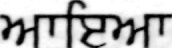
ਆਇਆ
